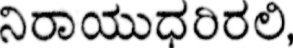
ನಿರಾಯುಧರಿರಲಿ,
